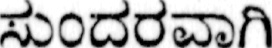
ಸುಂದರವಾಗಿ
